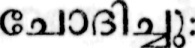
ചോദിച്ചു:
